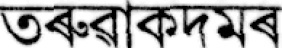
তৰুৱাকদমৰ
